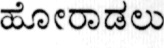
ಹೋರಾಡಲು
